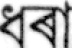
ধৰা
